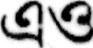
এও
